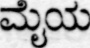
ಮೈಯ
